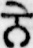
ਨੇ
